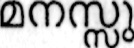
മനസ്സു
